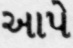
આપે
